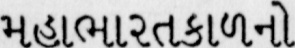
મહાભારતકાળનો
